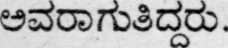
ಅವರಾಗುತಿದ್ದರು.
